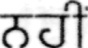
ਨਹੀਂ
